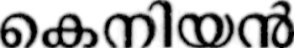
കെനിയന്‍
